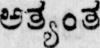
ಅತ್ಯಂತ
